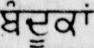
ਬੰਦੂਕਾਂ
